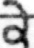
ਕੇ
